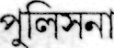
পুলিসনা
